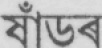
ষাঁডৰ
